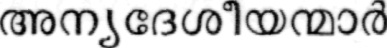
അന്യദേശീയന്മാര്‍
